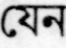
যেন
